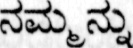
ನಮ್ಮನ್ನು
